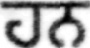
ਹਨ
